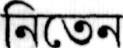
নিতেন
